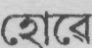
হোৱে
